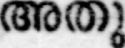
അതു
